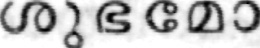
ശുഭമോ
